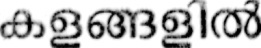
കളങ്ങളില്‍
